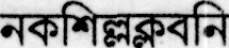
নকশিল্লক্লবনি
